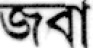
জবা
